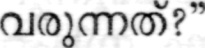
വരുന്നത്?”
